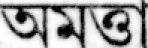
অমত্তা
